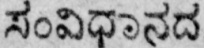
ಸಂವಿಧಾನದ
